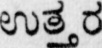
ಉತ್ತರ
